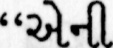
"એની
